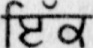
ਇੱਕ
